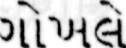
ગોખલે
